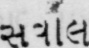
સવાલ
